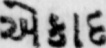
એકાદ
